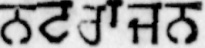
ਨਟਰਾਜਨ
